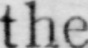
the
